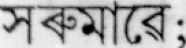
সৰুমাৱে;
